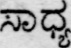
ಸಾಧ್ಯ
